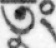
তুং
